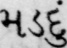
મડદું
